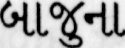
બાજુના
